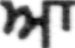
ਆ
